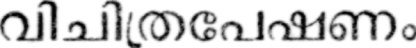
വിചിത്രപേഷണം
